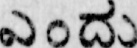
ಎಂದು
